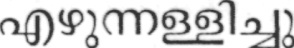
എഴുന്നള്ളിച്ചു
